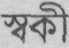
স্বকী
